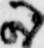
જે
